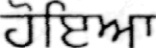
ਹੋਇਆ
